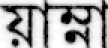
য়াম্না
